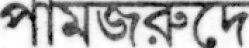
পামজরুদে
